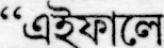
"এইফালে
